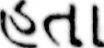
હતા
